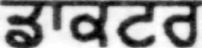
ਡਾਕਟਰ
